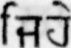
ਜਿਹੇ
